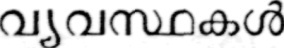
വ്യവസ്ഥകള്‍
